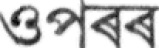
ওপৰৰ
